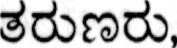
ತರುಣರು,
